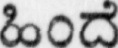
ಹಿಂದೆ
